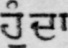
ਹੁੰਦਾ
